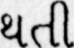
થતી
